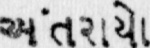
અંતરાયો
